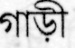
গাড়ী
